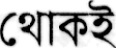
থোকই
